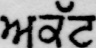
ਅਕੱਟ
